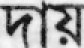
দায়
